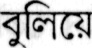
বুলিয়ে
